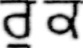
ਰੁਕ
